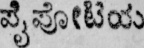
ಪೈಪೋಟಿಯ
